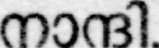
നാന്ദി.
